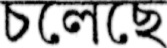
চলেছে
